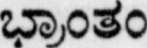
ಭ್ರಾಂತಂ
